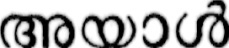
അയാള്‍
